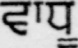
ਵਾਧੂ
